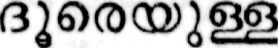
ദൂരെയുള്ള
